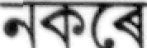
নকৰে
